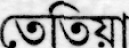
তেতিয়া
